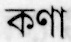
কণা
